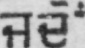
ਜਦੋਂ
